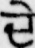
ਦੇ
